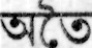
অতৈ
